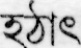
হঠাৎ
